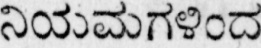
ನಿಯಮಗಳಿಂದ
